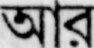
আর
